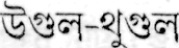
উগুল-থুগুল
